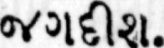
જગદીશ.
